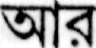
আর
